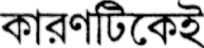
কারণটিকেই
